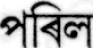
পৰিল
